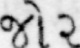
જોર
